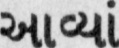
આવ્યાં
